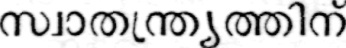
സ്വാതന്ത്ര്യത്തിന്
